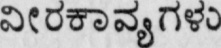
ವೀರಕಾವ್ಯಗಳು
